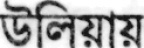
উলিয়ায়
